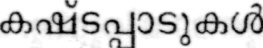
കഷ്ടപ്പാടുകള്‍
